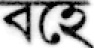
বহে
